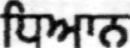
ਧਿਆਨ
